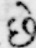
છે
